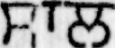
ਸਾਲ
